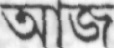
আজ
